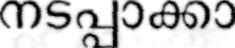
നടപ്പാക്കാ
